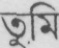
তুমি
